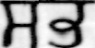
ਸਭ
